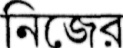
নিজের
